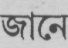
জানে
